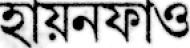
হায়নফাও
